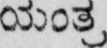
ಯಂತ್ರ
